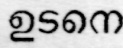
ഉടനെ
